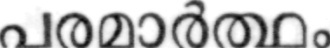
പരമാര്‍ത്ഥം
